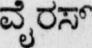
ವೈರಸ್
